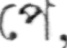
পে,
